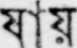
যায়
